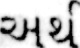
અર્થ
